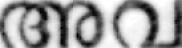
അവ
